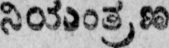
ನಿಯಂತ್ರಣ
